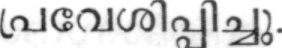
പ്രവേശിപ്പിച്ചു.
